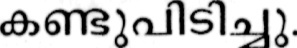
കണ്ടുപിടിച്ചു.
